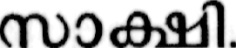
സാക്ഷി.
